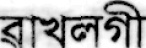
ৱাখলগী
